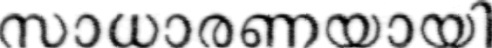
സാധാരണയായി
